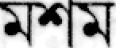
মশম
